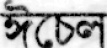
ঈচেল
